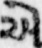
એ
